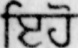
ਇਹੋ
